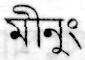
মীনুং
